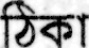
ঠিকা
